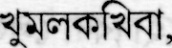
খুমলকখিবা,
